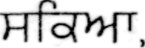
ਸਕਿਆ,
